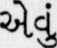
એવું
